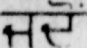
ਜਦੋਂ
